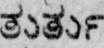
ತುರ್ತು
